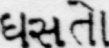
ઘસતો
